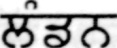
ਲੰਡਨ
